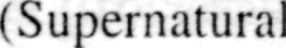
(Supernatural
